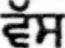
ਵੱਸ
